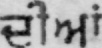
ਦੀਆਂ
